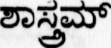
ಶಾಸ್ತ್ರಮ್
